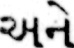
અને
